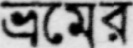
ভ্রমের
